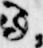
છે,
